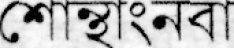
শোন্থাংনবা
